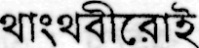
থাংথবীরোই
